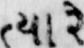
ત્યારે
